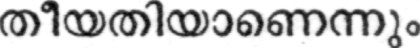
തീയതിയാണെന്നും
